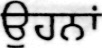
ਉਹਨਾਂ
